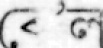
ৰে'ল
